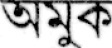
অমুক
